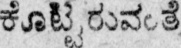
ಕೊಟ್ಟಿರುವಂತೆ
